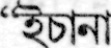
“ইচানা
